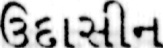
ઉદાસીન
